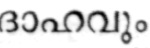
ദാഹവും
